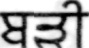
ਬੜੀ
